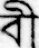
বী
